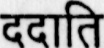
ददाति
